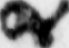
જ
